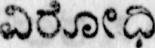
ವಿರೋಧಿ
